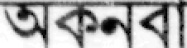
অকনবা
